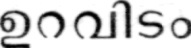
ഉറവിടം
